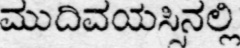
ಮುದಿವಯಸ್ಸಿನಲ್ಲಿ
